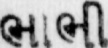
ભાભી
